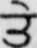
ਤੇ
